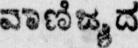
ವಾಣಿಜ್ಯದ
